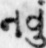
નવું
